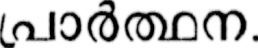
പ്രാര്‍ത്ഥന.
